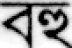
বহু
